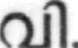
വി.
